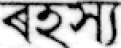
ৰহস্য
